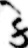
કે
